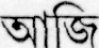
আজি
